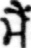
ਮੈਂ
